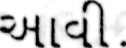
આવી.
